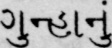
ગુન્હાનું
